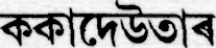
ককাদেউতাৰ
